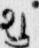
શું
